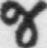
જ
